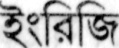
ইংরিজি
